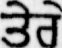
ਤੇਰੇ
